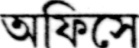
অফিসে
